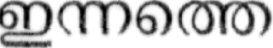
ഇന്നത്തെ
